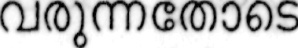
വരുന്നതോടെ
